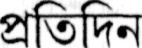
প্রতিদিন
